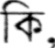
কি,
